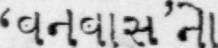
'વનવાસ'નો
